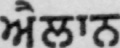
ਐਲਾਨ
